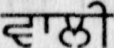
ਵਾਲੀ
